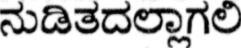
ನುಡಿತದಲ್ಲಾಗಲಿ
